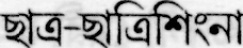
ছাত্র-ছাত্রিশিংনা
